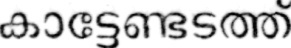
കാട്ടേണ്ടടത്ത്
